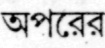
অপরের
